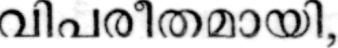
വിപരീതമായി,
